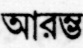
আরম্ভ
